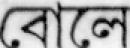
বোলে
